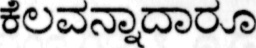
ಕೆಲವನ್ನಾದಾರೂ
